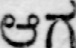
ಆಗ
